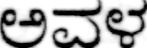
ಅವಳ
